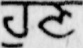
ਹੁਣ
